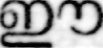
ഈ
